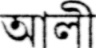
আলী
